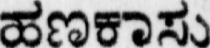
ಹಣಕಾಸು
